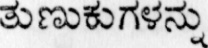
ತುಣುಕುಗಳನ್ನು
